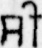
ਸੀ
